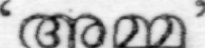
'അമ്മ'
